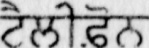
ਟੈਲੀਫ਼ੋਨ
